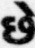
છે
